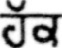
ਹੱਕ
